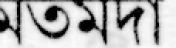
মতমদা
